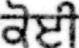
ਕੋਈ
